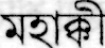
মহাক্কী
